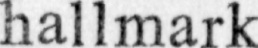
hallmark
